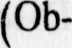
(ob-
